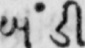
બંડી
